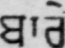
ਬਾਰੇ
